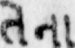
તેના
